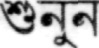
শুনুন
